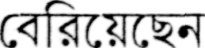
বেরিয়েছেন
